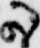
જે
